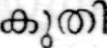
കുതി
